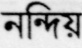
নন্দিয়
